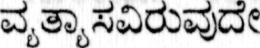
ವ್ಯತ್ಯಾಸವಿರುವುದೇ
